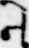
ને
